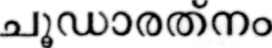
ചൂഡാരത്നം
